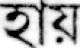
হায়
